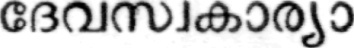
ദേവസ്വകാര്യാ
